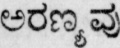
ಅರಣ್ಯವು
